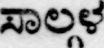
ಸಾಲ್ಗಳ
